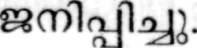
ജനിപ്പിച്ചു.
